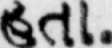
હતા.
